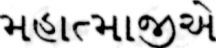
મહાત્માજીએ
